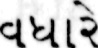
વધારે
